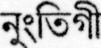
নুংতিগী
